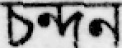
চন্দন
